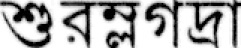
শুরম্লগদ্রা
